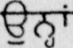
ਉਨ੍ਹਾਂ
